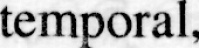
temporal,
